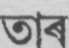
তাৰ
